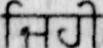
ਜਿਹੀ
